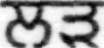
ਲੜ
